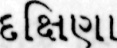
દક્ષિણા
